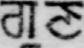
ਗੁਣ
